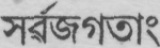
সৰ্ৱজগতাং
